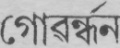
গোৱৰ্ন্ধন
